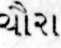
ચૌરા
